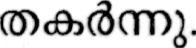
തകര്‍ന്നു.
